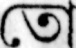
তো
